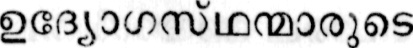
ഉദ്യോഗസ്ഥന്മാരുടെ
